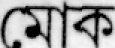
মোক
